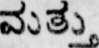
ಮತ್ತು
